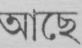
আছে
